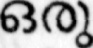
ഒരു
